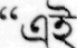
"এই
